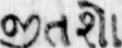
જીતશો
